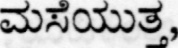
ಮಸೆಯುತ್ತ,
